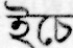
ইচে
